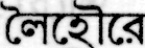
লৈহৌরে
